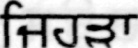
ਜਿਹੜਾ
